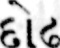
દોઢ
